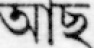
আছ
